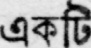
একটি
